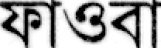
ফাওবা
